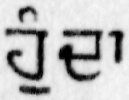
ਹੁੰਦਾ
